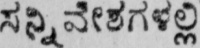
ಸನ್ನಿವೇಶಗಳಲ್ಲಿ
